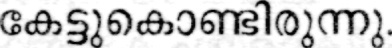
കേട്ടുകൊണ്ടിരുന്നു.
